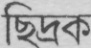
ছিদ্ৰক
